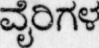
ವೈರಿಗಳ
